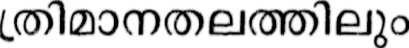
ത്രിമാനതലത്തിലും
